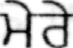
ਮੇਰੇ
